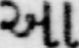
આ
